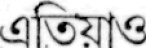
এতিয়াও
